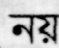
নয়
